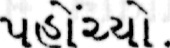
પહોંચ્યો.
